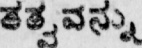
ತತ್ವವನ್ನು
